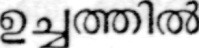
ഉച്ചത്തില്‍
